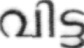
വിട്ട
